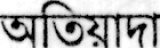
অতিয়াদা
